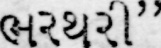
ભરથરી"
